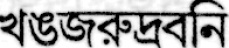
খঙজরুদ্রবনি
